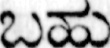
ಬಹು
